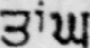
ਤਾਂਘ
